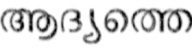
ആദ്യത്തെ
